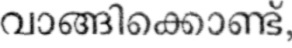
വാങ്ങിക്കൊണ്ട്,
